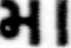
મા
